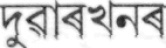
দুৱাৰখনৰ
